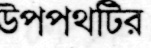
উপপথটির
